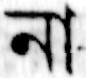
না
